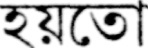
হয়তো
